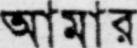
আমার
